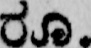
ರೂ.
